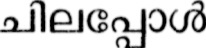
ചിലപ്പോള്‍
